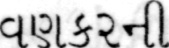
વણકરની
